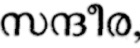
സന്ദീര,
